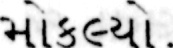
મોકલ્યો.
